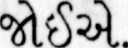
જોઈએ.
